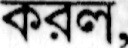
করল,
